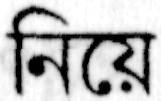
নিয়ে
